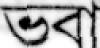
ভবা
